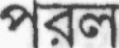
পরল
